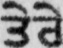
ਤੇਰੇ
